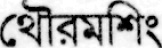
থৌরমশিং
